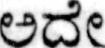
ಅದೇ
